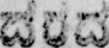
ದರದ
